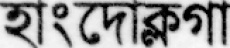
হাংদোক্লগা
